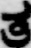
ತ
